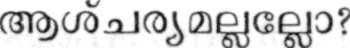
ആശ്ചര്യമല്ലല്ലോ?
